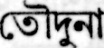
তৌদুনা
